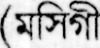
(মসিগী
